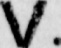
V.
